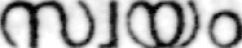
സ്വയം
